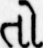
તો
